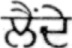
ਲੈਂਦੇ
